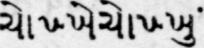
ચોખ્ખેચોખ્ખું
